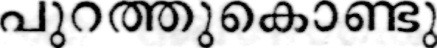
പുറത്തുകൊണ്ടു
